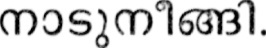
നാടുനീങ്ങി.
